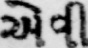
એવી
